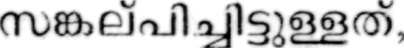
സങ്കല്പിച്ചിട്ടുള്ളത്,
